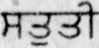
ਸਤੁਤੀ
